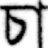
চা
